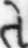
તે
